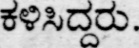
ಕಳಿಸಿದ್ದರು.
